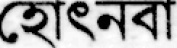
হোৎনবা
